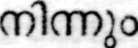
നിന്നും
